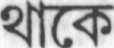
থাকে
